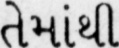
તેમાંથી
